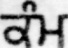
ਕੰਮ
